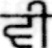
ਵੀ
